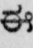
ಈ
